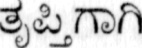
ತೃಪ್ತಿಗಾಗಿ
